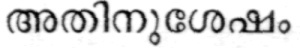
അതിനുശേഷം
